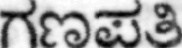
ಗಣಪತಿ
